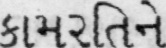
કામરતિને
